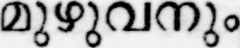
മുഴുവനും
